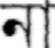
না
